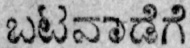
ಬಟವಾಡೆಗೆ
